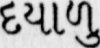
દયાળુ
